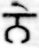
ਨੇ
